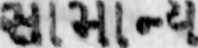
સામાન્ય
